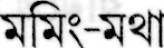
মমিং-মথা
